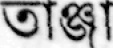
তাঞ্জা
